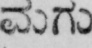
ಮಗು
